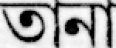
তানা
